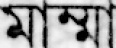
মাম্মা
